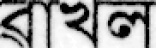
ৱাখল
